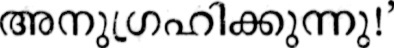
അനുഗ്രഹിക്കുന്നു!'
